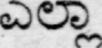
ಎಲ್ಲಾ
